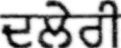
ਦਲੇਰੀ
